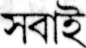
সবাই
